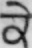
ਕੇ
